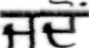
ਜਦੋਂ
